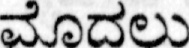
ಮೊದಲು
